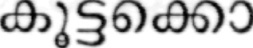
കൂട്ടക്കൊ
